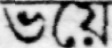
ভয়ে
